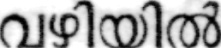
വഴിയില്‍
